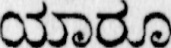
ಯಾರೂ
